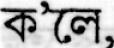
ক'লে,
